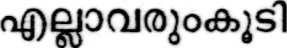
എല്ലാവരുംകൂടി
